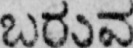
ಬರುವ
